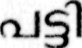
പട്ടി
